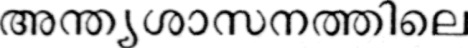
അന്ത്യശാസനത്തിലെ
